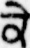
ਕੇ
